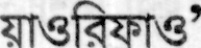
য়াওরিফাও’
